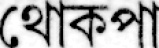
থোকপা
